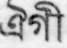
ঐগী
